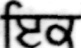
ਇਕ
